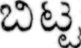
ಬಿಟ್ಟ
